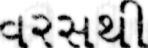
વરસથી
